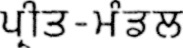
ਪ੍ਰੀਤ-ਮੰਡਲ
